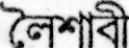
লৈশাবী
